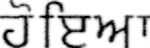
ਹੋਇਆ
